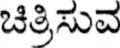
ಚಿತ್ರಿಸುವ
